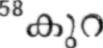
58കുറ
